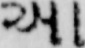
આ
